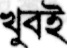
খুবই
